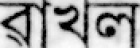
ৱাখল
